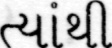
ત્યાંથી
